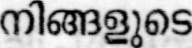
നിങ്ങളുടെ
